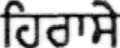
ਹਿਰਾਸੇ
